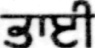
ਭਾਈ
